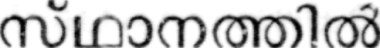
സ്ഥാനത്തില്‍
